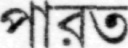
পারত
